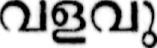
വളവു
